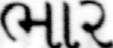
ભાર
